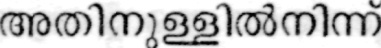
അതിനുള്ളില്‍നിന്ന്
